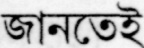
জানতেই
